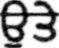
ਉਤੇ
